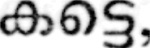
കട്ടെ,
